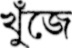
খুঁজে
